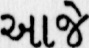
આજે
